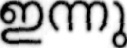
ഇന്നു
